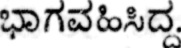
ಭಾಗವಹಿಸಿದ್ದ.
